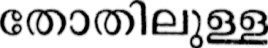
തോതിലുള്ള
